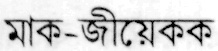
মাক-জীয়েকক
